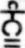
ਨੂੰ
